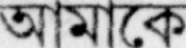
আমাকে
